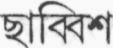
ছাব্বিশ
